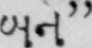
બન"
